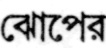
ঝোপের
